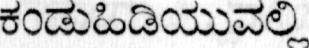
ಕಂಡುಹಿಡಿಯುವಲ್ಲಿ
